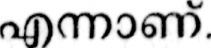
എന്നാണ്.
